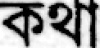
কথা
